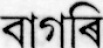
বাগৰি
